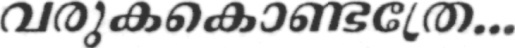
വരുകകൊണ്ടത്രേ...
